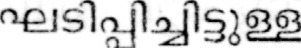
ഘടിപ്പിച്ചിട്ടുള്ള
